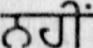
ਨਹੀਂ
